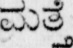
ಮತ್ತೆ
